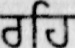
ਰਹਿ
